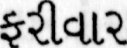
ફરીવાર
